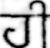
ਹੀ
